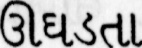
ઊઘડતા
